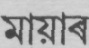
মায়াৰ
